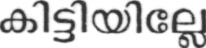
കിട്ടിയില്ലേ
